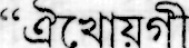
“ঐখোয়গী
